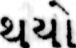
થયો
